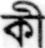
কী
